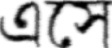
এসে
